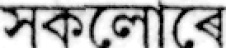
সকলোৰে
